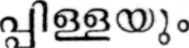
പ്പിള്ളയും
